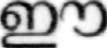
ഈ
